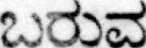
ಬರುವ
